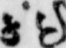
કંઈ
